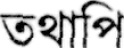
তথাপি
